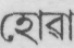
হোৱা
